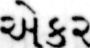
એકર
